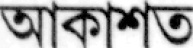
আকাশত
